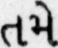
તમે
